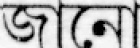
জানো
